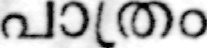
പാത്രം
